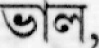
ভাল,
